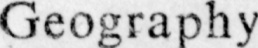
Geography
